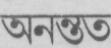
অনন্তত
